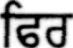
ਫਿਰ
